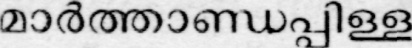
മാര്‍ത്താണ്ഡപ്പിള്ള
